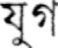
যুগ
